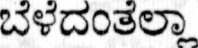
ಬೆಳೆದಂತೆಲ್ಲಾ
